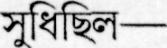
সুধিছিল-
